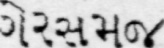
ગેરસમજ
